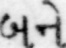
બને
